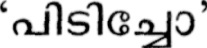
‘പിടിച്ചോ’
